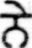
ਨੇ
